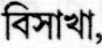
বিসাখা,
